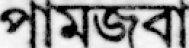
পামজবা
